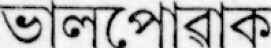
ভালপোৱাক
